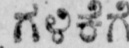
ಗಳಿಕೆಗೆ
